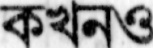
কখনও
